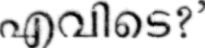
എവിടെ?'
